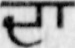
ਦਾ
